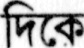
দিকে
